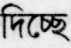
দিচ্ছে
